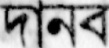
দানব
